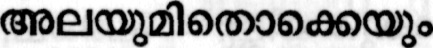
അലയുമിതൊക്കെയും
